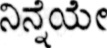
ನಿನ್ನೆಯೇ
